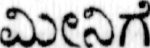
ಮೀನಿಗೆ
